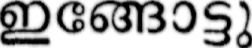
ഇങ്ങോട്ടു
